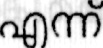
എന്ന്
